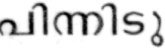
പിന്നിടു
